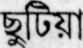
ছুটিয়া
